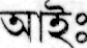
আইঃ
